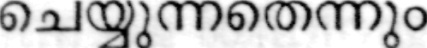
ചെയ്യുന്നതെന്നും
